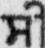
ਸੀ
